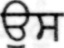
ਉਸ
